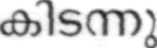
കിടന്നു
